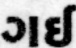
ગઈ
